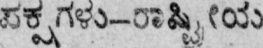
ಪಕ್ಷಗಳು-ರಾಷ್ಟ್ರೀಯ
